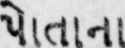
પોતાના
